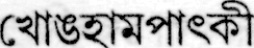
খোঙহামপাৎকী
